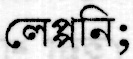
লেপ্পনি;
